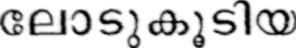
ലോടുകൂടിയ
